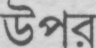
উপর
